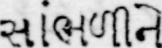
સાંભળીને
